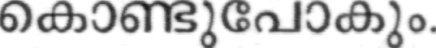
കൊണ്ടുപോകും.
